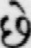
છે
